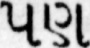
પણ
